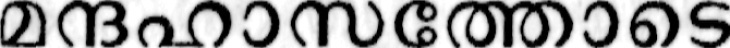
മന്ദഹാസത്തോടെ
